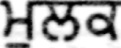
ਮੁਲਕ
